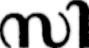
സി
